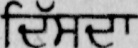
ਦਿੱਸਦਾ
